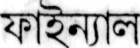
ফাইন্যাল
